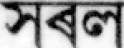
সৰল
